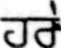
ਹਰ
